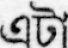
এটা
